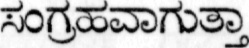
ಸಂಗ್ರಹವಾಗುತ್ತಾ
